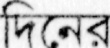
দিনের
